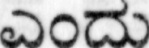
ಎಂದು
